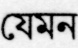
যেমন
